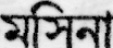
মসিনা
